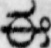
ಈ
